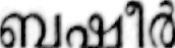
ബഷീര്‍
